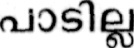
പാടില്ല
